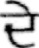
ਦੇ
